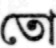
তো
